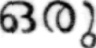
ഒരു
